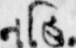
નહિ.
